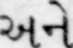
અને
